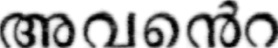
അവന്റെ
